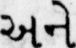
અને
